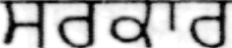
ਸਰਕਾਰ
